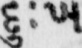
દુઃખ
